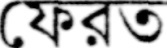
ফেরত
